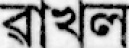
ৱাখল
